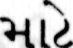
માટે
